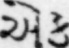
એક
